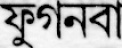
ফুগনবা
